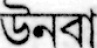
উনবা
